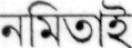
নমিতাই
